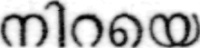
നിറയെ
